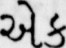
એક
